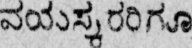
ವಯಸ್ಕರರಿಗೂ
